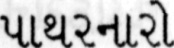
પાથરનારો
